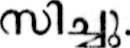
സിച്ചു.
